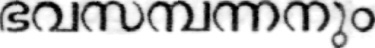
ഭവസമ്പന്നനും
